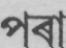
পৰা
